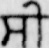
ਸੀ
